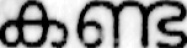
കണ്ട
